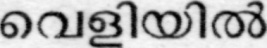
വെളിയില്‍
